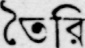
তৈরি
